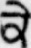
ਕੇ
